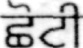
ਛੋਟੀ
